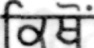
ਕਿਥੋਂ
